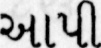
આપી
